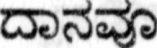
ದಾನವೂ
